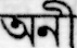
অনী
